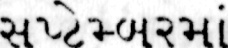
સપ્ટેમ્બરમાં
